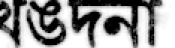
খঙদনা
